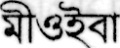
মীওইবা
